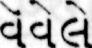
વૅવેલે
